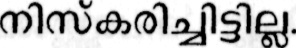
നിസ്കരിച്ചിട്ടില്ല.
